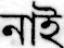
নাই
